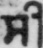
ਸੀ
